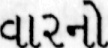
વારનો
